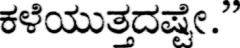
ಕಳೆಯುತ್ತದಷ್ಟೇ."
